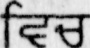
ਵਿਚ
